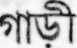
গাড়ী
